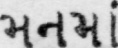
મનમાં
